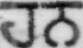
ਹਨ
